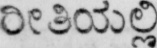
ರೀತಿಯಲ್ಲಿ
